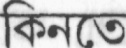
কিনতে
